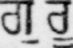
ਗੁਰੂ
